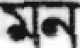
মন
